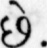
છે.
